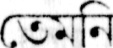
তেমনি
